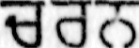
ਚਰਨ
